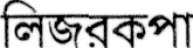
লিজরকপা
